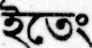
ইতেং
